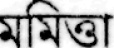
মমিত্তা
